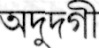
অদুদগী
